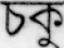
চকু
